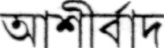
আশীর্বাদ
